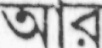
আর
